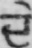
ਦੇ
